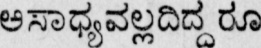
ಅಸಾಧ್ಯವಲ್ಲದಿದ್ದರೂ
